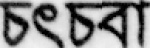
চৎচবা
